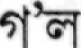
গ'ল
